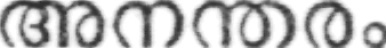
അനന്തരം
